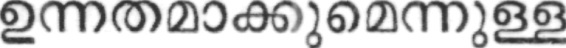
ഉന്നതമാക്കുമെന്നുള്ള
